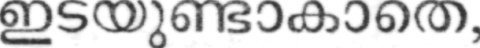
ഇടയുണ്ടാകാതെ,
